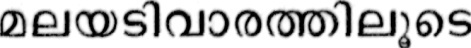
മലയടിവാരത്തിലൂടെ
